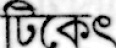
টিকেৎ
